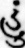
હું
